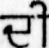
ਦੀ
